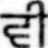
ਵੀ
